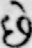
છે
